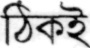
ঠিকই
